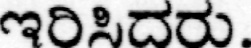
ಇರಿಸಿದರು.
